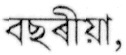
বছৰীয়া,
